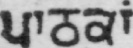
ਪਾਠਕਾਂ
